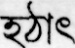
হঠাৎ
